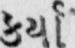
કર્યાં
